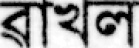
ৱাখল
